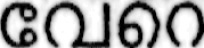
വേറെ
